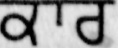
ਕਾਰ
